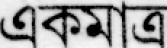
একমাত্র
